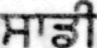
ਸਾਡੀ
